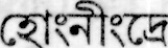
হোংনীংদ্রে
